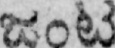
ಜಂಟ
